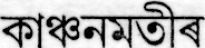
কাঞ্চনমতীৰ
